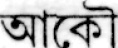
আকৌ
